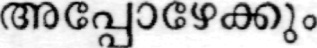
അപ്പോഴേക്കും
